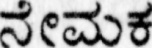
ನೇಮಕ
